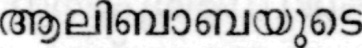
ആലിബാബയുടെ
